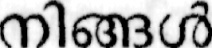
നിങ്ങള്‍
